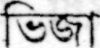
ভিজা
